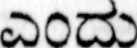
ಎಂದು
